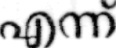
എന്ന്
